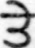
ਤੇ
